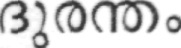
ദുരന്തം
